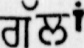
ਗੱਲਾਂ
